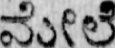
ಮೇಲೆ
